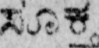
ಸೂಕ್ತ
